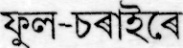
ফুল-চৰাইৰে
